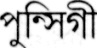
পুন্সিগী
